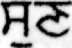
ਸੁਣ
